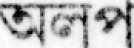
অলপ
